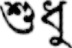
শুধু
